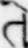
તે
